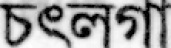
চৎলগা
